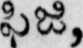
ಫಿಜಿ,
